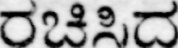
ರಚಿಸಿದ
